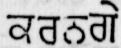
ਕਰਨਗੇ
